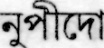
নুপীদো
